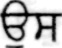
ਉਸ
